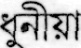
ধুনীয়া
